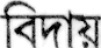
বিদায়
